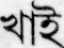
খাই
